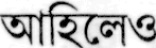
আহিলেও
